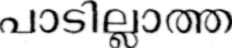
പാടില്ലാത്ത
